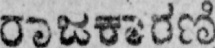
ರಾಜಕಾರಣಿ
